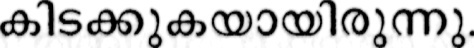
കിടക്കുകയായിരുന്നു.
